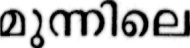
മുന്നിലെ
